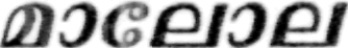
മാലോല
